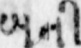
બની
